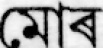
মোৰ
